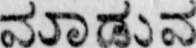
ಮಾಡುವ
